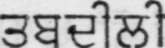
ਤਬਦੀਲੀ
